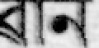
ৱান
